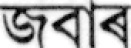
জবাৰ
